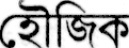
হৌজিক
